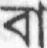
বা
